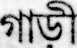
গাড়ী
